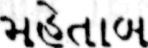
મહેતાબ
